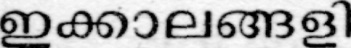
ഇക്കാലങ്ങളി
